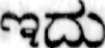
ಇದು
